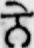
ਨੇ
